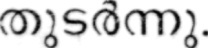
തുടര്‍ന്നു.
